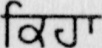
ਕਿਹਾ
